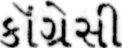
કૉંગ્રેસી
